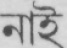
নাই
